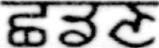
ਛਡਣ
